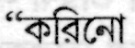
“করিনো
